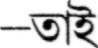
-তাই
